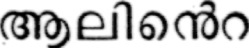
ആലിന്റെ
